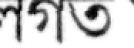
লগত
